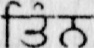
ਤਿੰਨ
